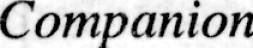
Companion
